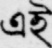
এই
